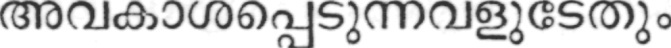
അവകാശപ്പെടുന്നവളുടേതും
